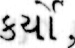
કર્યો,
